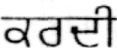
ਕਰਦੀ
